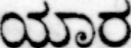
ಯಾರ
